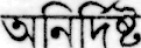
অনিৰ্দিষ্ট
